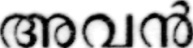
അവന്‍
